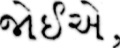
જોઈએ,
